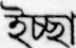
ইচ্ছা
